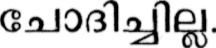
ചോദിച്ചില്ല.
